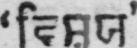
'ਵਿਸ਼ਯ'
